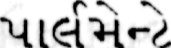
પાર્લમેન્ટે
